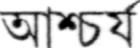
আশ্চর্য
